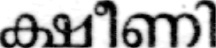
ക്ഷീണി
